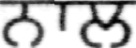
ਨਾਲ
